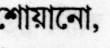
শোয়ানো,
